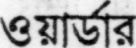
ওয়ার্ডার
